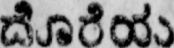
ದೊರೆಯ
